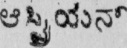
ಆಸ್ಟ್ರಿಯನ್
